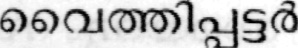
വൈത്തിപ്പട്ടര്‍
